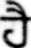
ਹੈ
